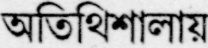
অতিথিশালায়
